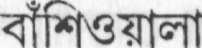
বাঁশিওয়ালা
